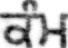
ਕੰਮ
